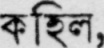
কহিল,
